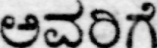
ಅವರಿಗೆ
